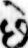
છે
